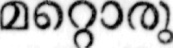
മറ്റൊരു
